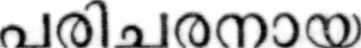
പരിചരനായ
